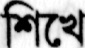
শিখে
